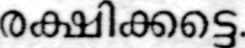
രക്ഷിക്കട്ടെ.
